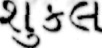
શુક્લ
